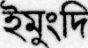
ইমুংদি
